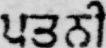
ਪਤਨੀ
